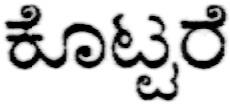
ಕೊಟ್ಟರೆ
